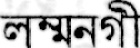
লম্মনগী
